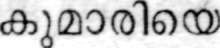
കുമാരിയെ
